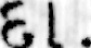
દા.
